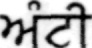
ਅੰਟੀ
